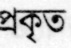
প্রকৃত
